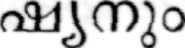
ഷ്യനും
